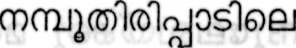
നമ്പൂതിരിപ്പാടിലെ
